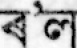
ৰ'ল
